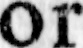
or
